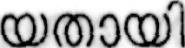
യതായി
